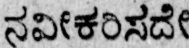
ನವೀಕರಿಸದೇ
